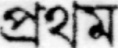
প্রথম
